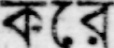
করে
